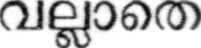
വല്ലാതെ
